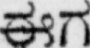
ಈಗ
